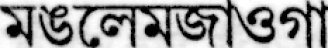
মঙলেমজাওগা
